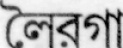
লৈরগা
